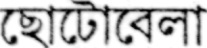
ছোটোবেলা
